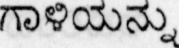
ಗಾಳಿಯನ್ನು
